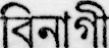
বিনাগী
